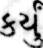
કર્યું
